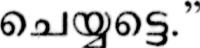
ചെയ്യട്ടെ.”
